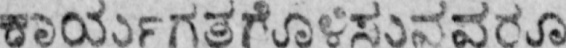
ಕಾರ್ಯಗತಗೊಳಿಸುವವರೂ
